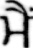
ਮੈਂ
